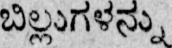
ಬಿಲ್ಲುಗಳನ್ನು
